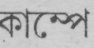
কাম্পে
